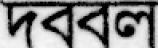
দববল
